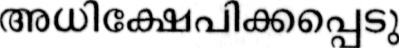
അധിക്ഷേപിക്കപ്പെടു
